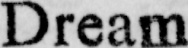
Dream
